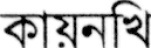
কায়নখি
